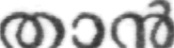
താന്‍
